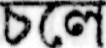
চলে
